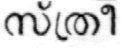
സ്ത്രീ
